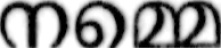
നമ്മെ
